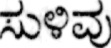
ಸುಳಿವು
